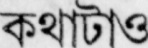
কথাটাও
